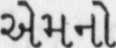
એમનો
